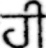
ਹੀ
